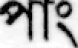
পাং
